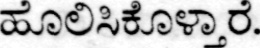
ಹೊಲಿಸಿಕೊಳ್ತಾರೆ.
